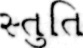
સ્તુતિ
